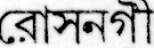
রোসনগী
